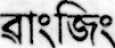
ৱাংজিং
